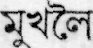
মুখলৈ
